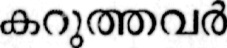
കറുത്തവര്‍
